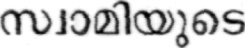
സ്വാമിയുടെ
